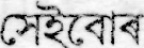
সেইবোৰ
